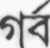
গর্ব
